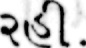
રહી.
